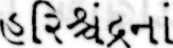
હરિશ્ર્ચંદ્રનાં
